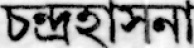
চন্দ্রহাসনা
